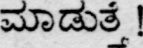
ಮಾಡುತ್ತೆ!
